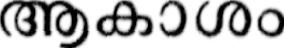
ആകാശം
